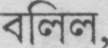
বলিল,
